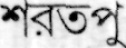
শরতপু
